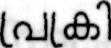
പ്രക്രി
